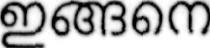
ഇങ്ങനെ
